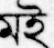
মই
